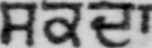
ਸਕਦਾ
